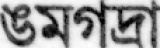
ঙমগদ্রা
